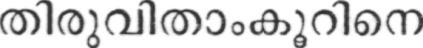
തിരുവിതാംകൂറിനെ
